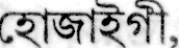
হোজাইগী,
